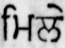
ਮਿਲੇ
